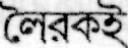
লৈরকই
